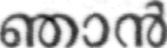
ഞാന്‍
